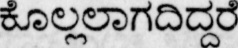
ಕೊಲ್ಲಲಾಗದಿದ್ದರೆ
